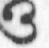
ও
